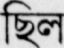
ছিল
